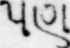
પણ
